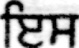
ਇਸ
